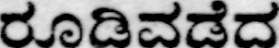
ರೂಡಿವಡೆದ
